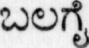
ಬಲಗೈ
